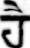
ਹੈ
